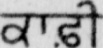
ਕਾਫ਼ੀ
